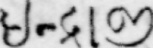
ઈન્દ્રાજી
